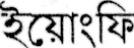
ইয়োংফি
